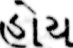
હોય
